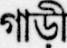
গাড়ী
